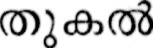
തുകല്‍
